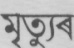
মৃত্যুৰ
